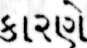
કારણે
